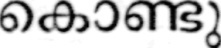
കൊണ്ടു
